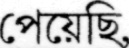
পেয়েছি,
